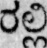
ರಲ್ಲಿ
